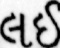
લઈ
